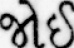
જોઈ
